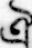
ঐ
